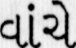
વાંચે
